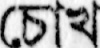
চোখ
